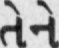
તેને
